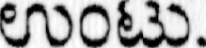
ಉಂಟು.
